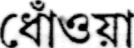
ধোঁওয়া
